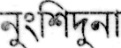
নুংশিদুনা
